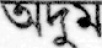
অদুম
